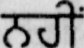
ਨਹੀਂ
